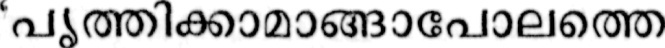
‘പൃത്തിക്കാമാങ്ങാപോലത്തെ
